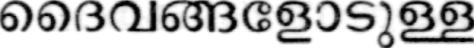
ദൈവങ്ങളോടുള്ള
